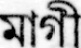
মাগী
